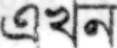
এখন
